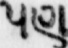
પણ
